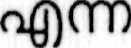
എന്ന
